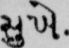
સુખે.
